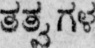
ತತ್ವಗಳ
